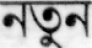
নতুন
